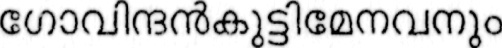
ഗോവിന്ദന്‍കുട്ടിമേനവനും
